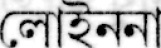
লোইননা
